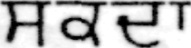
ਸਕਦਾ
